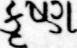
કૃષ્ણ
